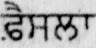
ਫ਼ੈਸਲਾ
